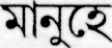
মানুহে
